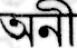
অনী
